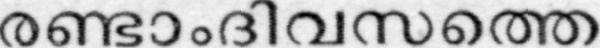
രണ്ടാംദിവസത്തെ
